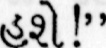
હશે!"
